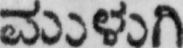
ಮುಳುಗಿ
